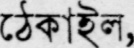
ঠেকাইল,
